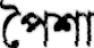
পৈশা
